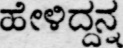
ಹೇಳಿದ್ದನ್ನ
